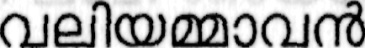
വലിയമ്മാവന്‍
